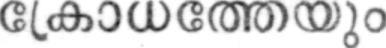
ക്രോധത്തേയും
